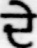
ਦੇ
